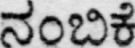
ನಂಬಿಕೆ
